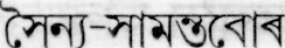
সৈন্য-সামন্তবোৰ
